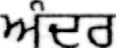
ਅੰਦਰ
